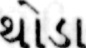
થોડા
